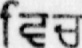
ਵਿਚ
